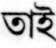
তাই
